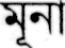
মূনা
